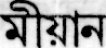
মীয়ান
